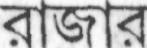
রাজার
